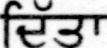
ਦਿੱਤਾ
